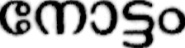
നോട്ടം
